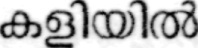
കളിയില്‍
